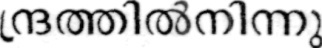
ന്ദ്രത്തില്‍നിന്നു
